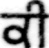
ਕੀ
